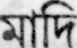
মাদি
